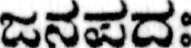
ಜನಪದಃ
